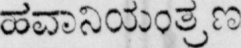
ಹವಾನಿಯಂತ್ರಣ
